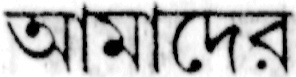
আমাদের
